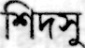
শিদসু
